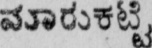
ಮಾರುಕಟ್ಟೆ
